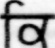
ਕਿ
